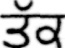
ਤੱਕ
